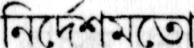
নির্দেশমতো
